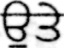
ਉਤੇ
